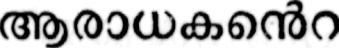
ആരാധകന്റെ
